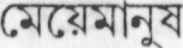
মেয়েমানুষ
